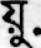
য়ু.
